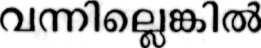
വന്നില്ലെങ്കില്‍
